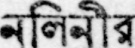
নলিনীর
